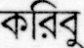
করিবু
